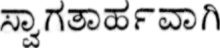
ಸ್ವಾಗತಾರ್ಹವಾಗಿ
